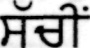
ਸੱਚੀਂ
